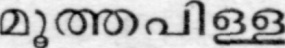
മൂത്തപിള്ള
